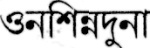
ওনশিন্নদুনা
